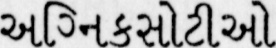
અગ્નિકસોટીઓ
